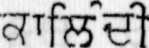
ਕਾਲਿੰਦੀ
